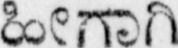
ಹೀಗಾಗಿ
